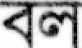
বল
